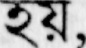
হয়,
